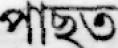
পাছত
